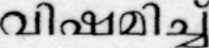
വിഷമിച്ച്
